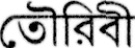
তৌরিবী
